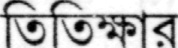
তিতিক্ষার
